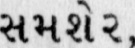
સમશેર,
